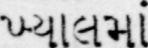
ખ્યાલમાં
